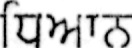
ਧਿਆਨ
